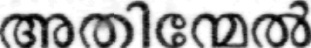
അതിന്മേല്‍
